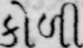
કોળી
